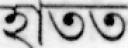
হাতত
